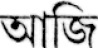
আজি
